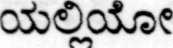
ಯಲ್ಲಿಯೋ
